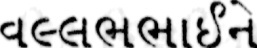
વલ્લભભાઈને
